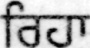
ਰਿਹਾ
